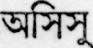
অসিসু
